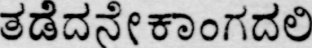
ತಡೆದನೇಕಾಂಗದಲಿ
